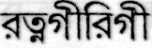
রত্নগীরিগী
